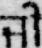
ਜੀ
